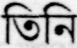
তিনি
